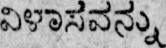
ವಿಳಾಸವನ್ನು
